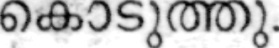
കൊടുത്തു.
